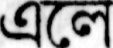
এলে
